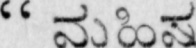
“ಮಹಿಷ
